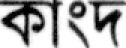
কাংদ
